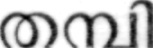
തമ്പി
